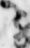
કે
